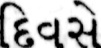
દિવસે
